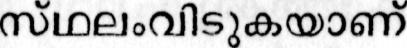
സ്ഥലംവിടുകയാണ്
